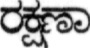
ರಕ್ಷಣಾ
